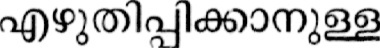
എഴുതിപ്പിക്കാനുള്ള
